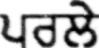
ਪਰਲੇ
